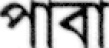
পাবা
